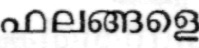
ഫലങ്ങളെ
